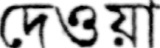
দেওয়া
